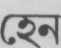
হেন
